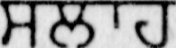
ਸਲਾਹ
